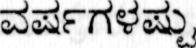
ವರ್ಷಗಳಷ್ಟು
